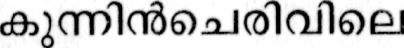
കുന്നിന്‍ചെരിവിലെ
